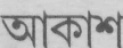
আকাশ
